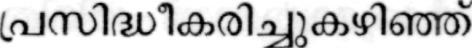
പ്രസിദ്ധീകരിച്ചുകഴിഞ്ഞ്
